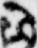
છે
